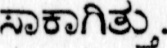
ಸಾಕಾಗಿತ್ತು.
